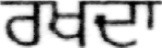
ਰਖਦਾ
